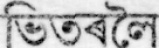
ভিতৰলৈ
